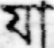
যা
